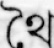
থৈ
